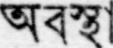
অবস্থা
